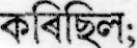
কৰিছিল;
